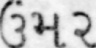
ઉંમર
